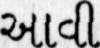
આવી
